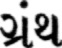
ગ્રંથ
